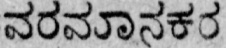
ವರಮಾನಕರ
